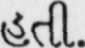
હતી.
